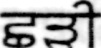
ਛੜੀ
